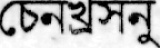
চেনখ্রসনু
